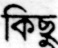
কিছু
